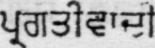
ਪ੍ਰਗਤੀਵਾਦੀ
